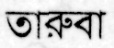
তারুবা
